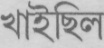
খাইছিল
